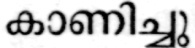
കാണിച്ചു.
